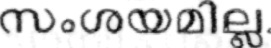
സംശയമില്ല.
